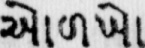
ઓળખો
